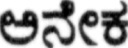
ಅನೇಕ
